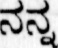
ನನ್ನ
